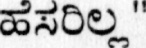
ಹೆಸರಿಲ್ಲ”
